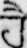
ਹੈ
